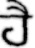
ਹੈ
